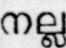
നല്ല
